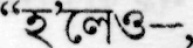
"হ'লেও-,
